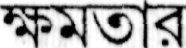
ক্ষমতার
